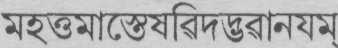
মহত্তমাস্তেষৱিদদ্ভৱানযম্‌
